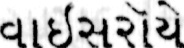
વાઇસરૉયે
